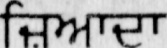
ਜ਼ਿਆਦਾ
